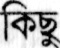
কিছু
